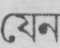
যেন
